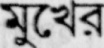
মুখের
